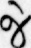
જે
